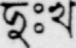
দুঃখ
